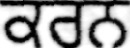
ਕਰਨ
